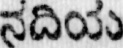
ನದಿಯ
